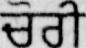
ਚੋਰੀ
